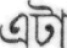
এটা
